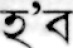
হ'ব
